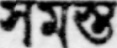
সমস্ত
